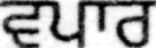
ਵਪਾਰ
